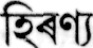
হিৰণ্য
